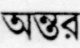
অন্তর
